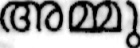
അമ്മു
